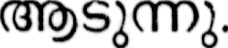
ആടുന്നു.
